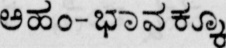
ಅಹಂ-ಭಾವಕ್ಕೂ
